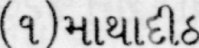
(૧)માથાદીઠ
